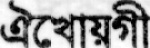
ঐখোয়গী
